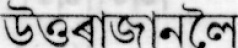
উত্তৰাজানলৈ
